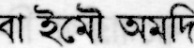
হনবীরক্লগনুদা
